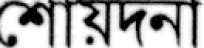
শোয়দনা
